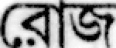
রোজ
